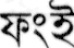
ফংই
